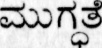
ಮುಗ್ಧತೆ
